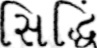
સિદ્ધિં
